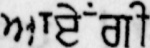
ਆਏਂਗੀ
